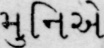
મુનિએ
